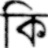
কি
